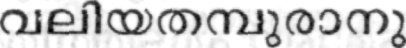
വലിയതമ്പുരാനു
